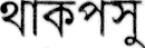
থাকপসু
